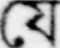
যে
